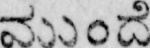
ಮುಂದೆ
